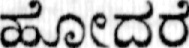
ಹೋದರೆ
